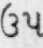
ઉપ
